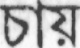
চায়
